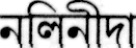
নলিনীদা
